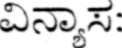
ವಿನ್ಯಾಸ:
